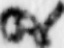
જ
